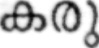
കരു
